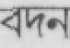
বদন
